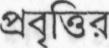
প্রবৃত্তির
